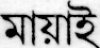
মায়াই
